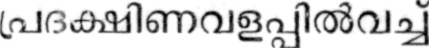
പ്രദക്ഷിണവളപ്പില്‍വച്ച്
